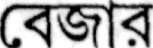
বেজার
